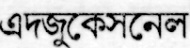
এদজুকেসনেল
